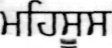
ਮਹਿਸੂਸ
